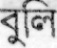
বুলি
